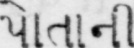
પોતાની
